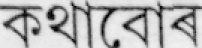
কথাবোৰ
